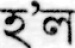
হ'ল
